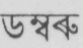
ডম্বৰু
